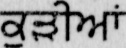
ਕੁੜੀਆਂ
